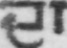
ਦਾ
